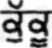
ਕੁੱਕੂ
